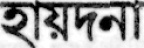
হায়দনা
